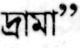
দ্রামা”
